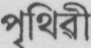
পৃথিৱী
